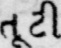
તૂટી
